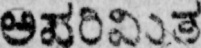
ಅಪರಿಮಿತ
